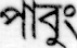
পাবুং
